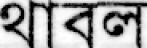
থাবল
